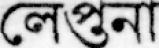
লেপ্তনা
